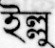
ইল্লু
